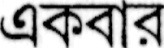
একবার
